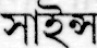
সাইন্স
